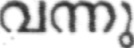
വന്നു
